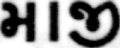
માજી
